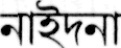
নাইদনা
